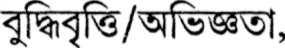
বুদ্বিবৃত্তি/অভিজ্ঞতা,
